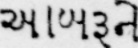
આબરૂને
